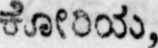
ಕೋರಿಯ,
